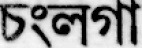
চংলগা
